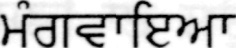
ਮੰਗਵਾਇਆ
